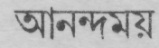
আনন্দময়
